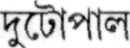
দুটোপাল
